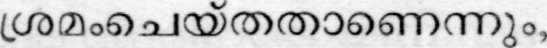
ശ്രമംചെയ്തതാണെന്നും,
